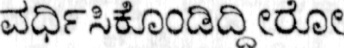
ವರ್ಧಿಸಿಕೊಂಡಿದ್ದೀರೋ
